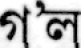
গ'ল
